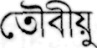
তৌবীয়ু
